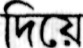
দিয়ে
